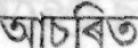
আচৰিত
